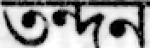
তন্দন
